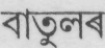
বাতুলৰ
